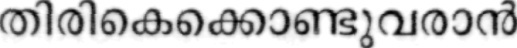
തിരികെക്കൊണ്ടുവരാന്‍
